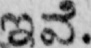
ಇವೆ.
